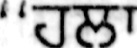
''ਹਲਾ
